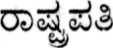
ರಾಷ್ಟ್ರಪತಿ
